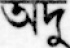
অদু
